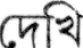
দেখি
